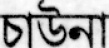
চাউনা
